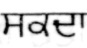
ਸਕਦਾ
